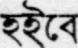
হইবে
